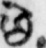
છે.
